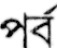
পর্ব
